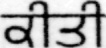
ਕੀਤੀ
